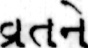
વ્રતને
